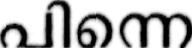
പിന്നെ
